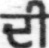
ਦੀ
